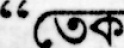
“তেক
